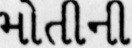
મોતીની
